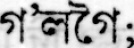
গ'লগৈ;
